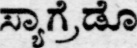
ಸ್ಯಾಗ್ರೆಡೊ
